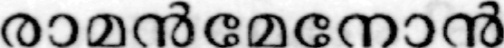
രാമന്‍മേനോന്‍
